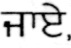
ਜਾਏ,
